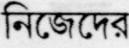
নিজেদের
